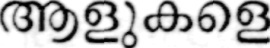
ആളുകളെ
